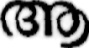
ആ
